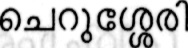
ചെറുശ്ശേരി
